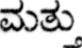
ಮತ್ತು
